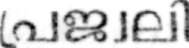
പ്രജ്വലി
